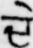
ਦੇ
